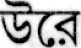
উরে
